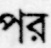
পর
